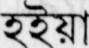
হইয়া
